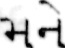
મને
